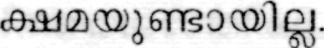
ക്ഷമയുണ്ടായില്ല.
